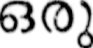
ഒരു
